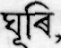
ঘূৰি,
